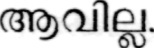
ആവില്ല.
